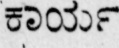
ಕಾರ್ಯ
